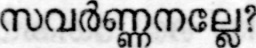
സവര്‍ണ്ണനല്ലേ?
